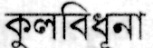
কুলবিধূনা
